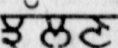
ਝੱਲਣ
